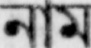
নাম
